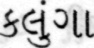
કલુંગા
